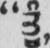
''ਤੂੰ,
